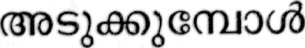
അടുക്കുമ്പോള്‍
